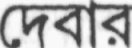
দেবার
